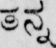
ತನ್ನ
